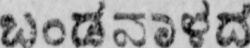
ಬಂಡವಾಳದ
